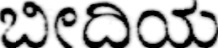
ಬೀದಿಯ
